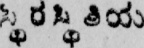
ಸ್ಥಿರಸ್ಥಿತಿಯ
